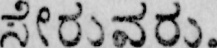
ಸೇರುವರು.
